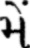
મેં
